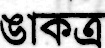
ঙাকত্র
